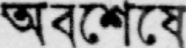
অবশেষে
